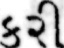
કરી
